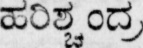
ಹರಿಶ್ಚಂದ್ರ
